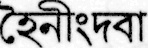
হৈনীংদবা
